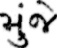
મુંજે
